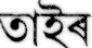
তাইৰ
